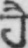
ਹੈ
